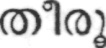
തീരൂ
